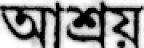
আশ্রয়
